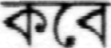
কবে
